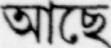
আছে
